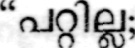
“പറ്റില്ല;
